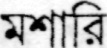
মশারি
